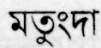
মতুংদা
